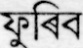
ফুৰিব
